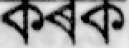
কৰক
